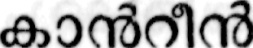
കാൻറീൻ
